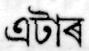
এটাৰ
